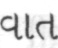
વાત
